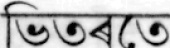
ভিতৰতে
